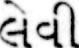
લેવી
